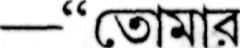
-"তোমার
